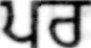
ਪਰ
